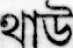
থাউ
